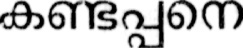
കണ്ടപ്പനെ
